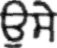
ਉਸੇ
